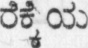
ರೆಕ್ಕೆಯ
